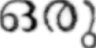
ഒരു
